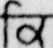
ਕਿ
